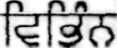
ਵਿਭਿੰਨ
